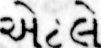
એટલે
